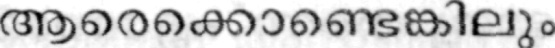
ആരെക്കൊണ്ടെങ്കിലും
